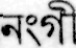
নংগী
